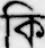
কি
